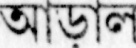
আড়াল
